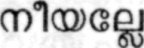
നീയല്ലേ
